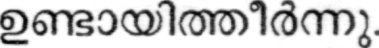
ഉണ്ടായിത്തീര്‍ന്നു.
